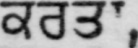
ਕਰਤਾ,
